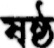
ষষ্ঠ
